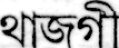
থাজগী
